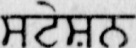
ਸਟੇਸ਼ਨ
